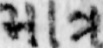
માત્ર
